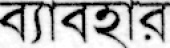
ব্যাবহার
